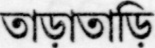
তাড়াতাড়ি
